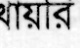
খায়রি
